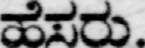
ಹೆಸರು.
